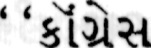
"કૉંગ્રેસ
